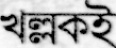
খল্লকই
